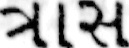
ત્રાસ
